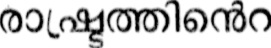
രാഷ്ട്രത്തിന്റെ
